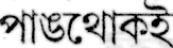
পাঙথোকই
